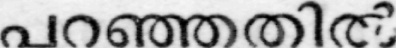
പറഞ്ഞതില്‍
